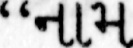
"નામ
